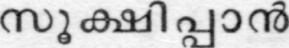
സൂക്ഷിപ്പാന്‍
